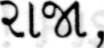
રાજા,
